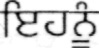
ਇਹਨੂੰ
